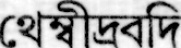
থেম্বীদ্রবদি
